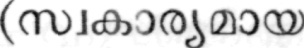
(സ്വകാര്യമായ
